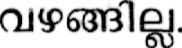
വഴങ്ങില്ല.
